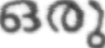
ഒരു
